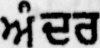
ਅੰਦਰ
